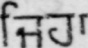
ਜਿਹਾ
